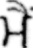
ਮੈਂ
